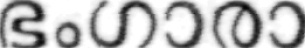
ഭംഗാരാ
